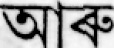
আৰু
